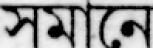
সমানে
